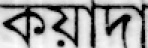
কয়াদা
